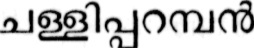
ചള്ളിപ്പറമ്പന്‍
